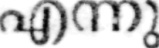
എന്നു
